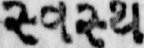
સ્વસ્થ
